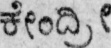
ಕೇಂದ್ರೀ
